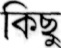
কিছু
